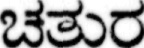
ಚತುರ
